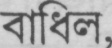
বাধিল,
